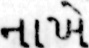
નાખે
